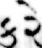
કરે
